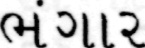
ભંગાર
